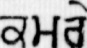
ਕਮਰੇ
